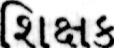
શિક્ષક
